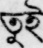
তুই
